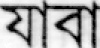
যাবা
